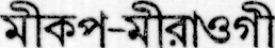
মীকপ-মীরাওগী
